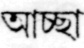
আচ্ছা
